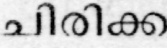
ചിരിക്ക
